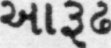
આરૂઢ
